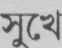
সুখে
